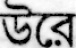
উরে
